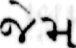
જેમ
